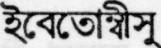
ইবেতোম্বীসু
